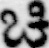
ಚಿ
